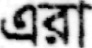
এরা
